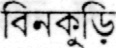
বিনকুড়ি
